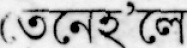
তেনেহ'লে
